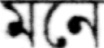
মনে
